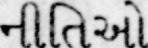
નીતિઓ
